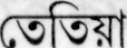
তেতিয়া
